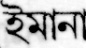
ইমানা
